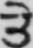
ਤੇ
